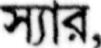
স্যার,
